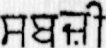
ਸਬਜ਼ੀ
